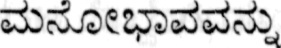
ಮನೋಭಾವವನ್ನು
